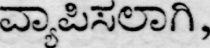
ವ್ಯಾಪಿಸಲಾಗಿ,
